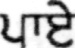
ਪਾਏ
